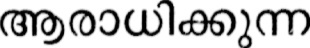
ആരാധിക്കുന്ന
